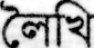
লৈখি
